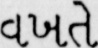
વખતે
